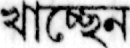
খাচ্ছেন
